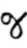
જ
